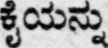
ಕೈಯನ್ನು
